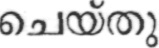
ചെയ്തു
